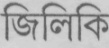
জিলিকি
